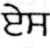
ਏਸ
